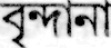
বৃন্দানা
